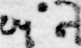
બંને
